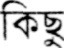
কিছু
